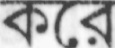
করে
